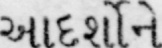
આદર્શોને
